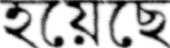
হয়েছে
